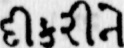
દીકરીને
